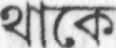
থাকে
